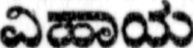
ವಿಹಾಯ
